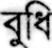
বুধি
